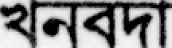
খনবদা
